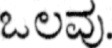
ಒಲವು.
